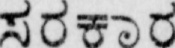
ಸರಕಾರ
